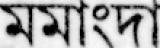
মমাংদা
